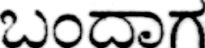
ಬಂದಾಗ
